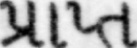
પ્રાપ્ત
